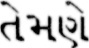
તેમણે
